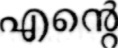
എന്റെ
